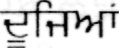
ਦੂਜਿਆਂ
